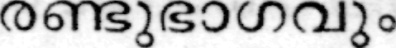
രണ്ടുഭാഗവും
